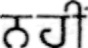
ਨਹੀਂ
